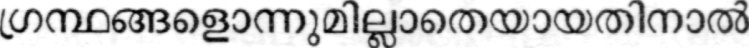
ഗ്രന്ഥങ്ങളൊന്നുമില്ലാതെയായതിനാല്‍
